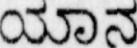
ಯಾನ
